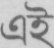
এই
